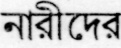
নারীদের
